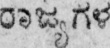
ರಾಜ್ಯಗಳ
